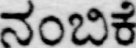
ನಂಬಿಕೆ
